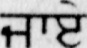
ਜਾਏ
